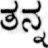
ತನ್ನ
